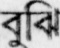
বুঝি
